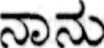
ನಾನು
